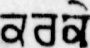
ਕਰਕੇ
